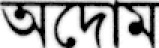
অদোম
